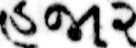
હજાર
